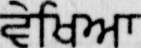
ਵੇਖਿਆ
